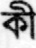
কী
